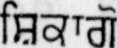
ਸ਼ਿਕਾਗੋ
